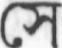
সে
